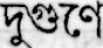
দুগুণে
